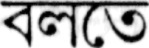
বলতে
